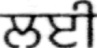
ਲਈ
